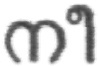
നീ
